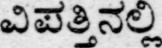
ವಿಪತ್ತಿನಲ್ಲಿ
